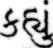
કહ્યું
